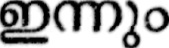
ഇന്നും
